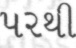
પરથી
